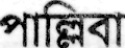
পাল্লিবা
